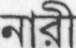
নারী
